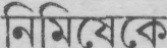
নিমিষেকে
